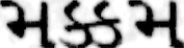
મક્કમ
